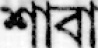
শাবা
